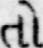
તો
